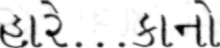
હારે...કાનો
